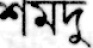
শমদু
